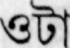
ওটা
